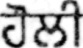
ਹੌਲੀ
